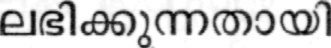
ലഭിക്കുന്നതായി
